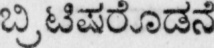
ಬ್ರಿಟಿಷರೊಡನೆ
